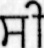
ਸੀ
